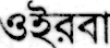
ওইরবা
